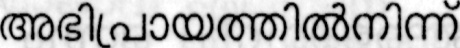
അഭിപ്രായത്തില്‍നിന്ന്
